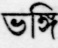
ভঙ্গি
